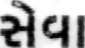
સેવા
